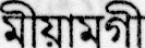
মীয়ামগী
